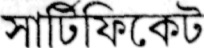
সার্টিফিকেট
